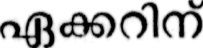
ഏക്കറിന്
